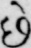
છે
